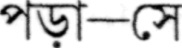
পড়া–সে
